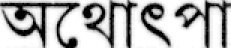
অথোৎপা
